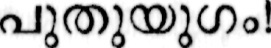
പുതുയുഗം!
